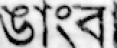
ঙাংবা
